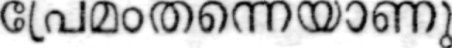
പ്രേമംതന്നെയാണു
